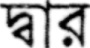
দ্বার
